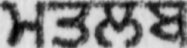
ਮਤਲਬ
